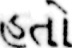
હતો
